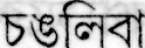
চঙলিবা
